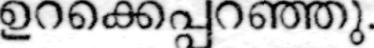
ഉറക്കെപ്പറഞ്ഞു.
